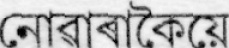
নোৱাৰাকৈয়ে
